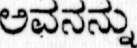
ಅವನನ್ನು
